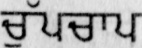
ਚੁੱਪਚਾਪ
